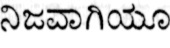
ನಿಜವಾಗಿಯೂ
